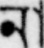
না
